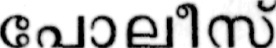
പോലീസ്
